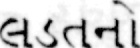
લડતનો
